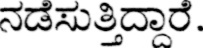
ನಡೆಸುತ್ತಿದ್ದಾರೆ.
